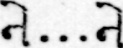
ને...ને
